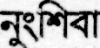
নুংশিবা
